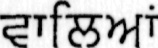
ਵਾਲਿਆਂ
